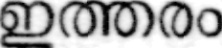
ഇത്തരം
